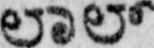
ಲಾಲ್
